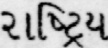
રાષ્ટ્રિય
